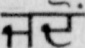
ਜਦੋਂ
